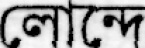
লোন্দে
